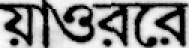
য়াওররে
